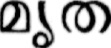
മൃത
